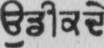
ਉਡੀਕਦੇ
